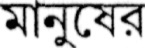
মানুষের
